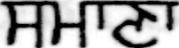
ਸਮਾਣਾ
